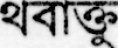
থবাক্তু
